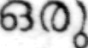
ഒരു
